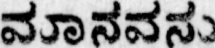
ಮಾನವನು
